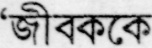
‘জীবককে
